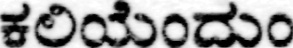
ಕಲಿಯೆಂದುಂ
